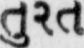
તુરત
